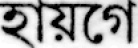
হায়গে
